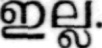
ഇല്ല.
